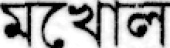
মখোল
